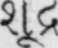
શુદ્ર
